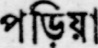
পড়িয়া
